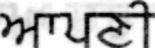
ਆਪਣੀ
